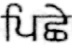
ਪਿਛੇ
